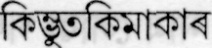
কিম্ভুতকিমাকাৰ
